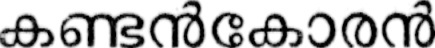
കണ്ടന്‍കോരന്‍
